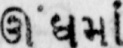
ઊંધમાં
